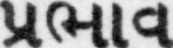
પ્રભાવ
